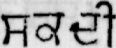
ਸਕਦੀ
